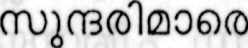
സുന്ദരിമാരെ
